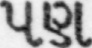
પણ
